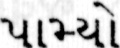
પામ્યો
